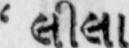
લીલા
